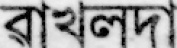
ৱাখলদা
